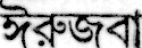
ঈরুজবা
